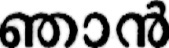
ഞാന്‍
